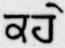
ਕਹੇ
